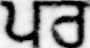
ਪਰ
